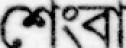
শেংবা
